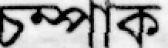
চম্পাক
